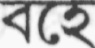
বহে
